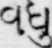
પડતી
